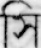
সি
